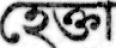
হেক্তা
